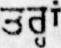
ਤਰ੍ਹਾਂ
